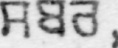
ਸਬਰ,
